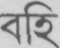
বহি
